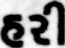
હરી
